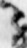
કે
